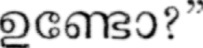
ഉണ്ടോ?"
